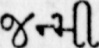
જન્મી
